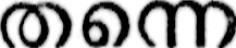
തന്നെ
